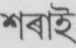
শৰাই
